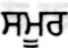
ਸਮੂਰ
